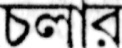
চলার
